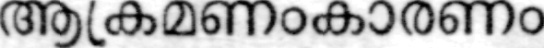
ആക്രമണംകാരണം
